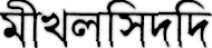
মীখলসিদদি
